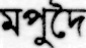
মপুদৈ
